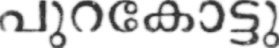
പുറകോട്ടു
